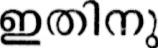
ഇതിനു
